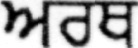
ਅਰਥ
